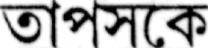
তাপসকে
